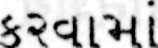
કરવામાં
